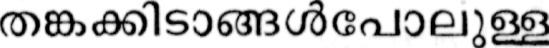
തങ്കക്കിടാങ്ങള്‍പോലുള്ള
